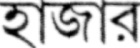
হাজার
